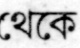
থেকে
